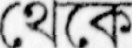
থেকে
